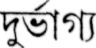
দুর্ভাগ্য
